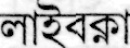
লাইবক্না
